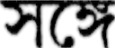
সঙ্গে
